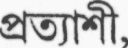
প্রত্যাশী,
